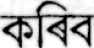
কৰিব
